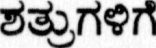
ಶತ್ರುಗಳಿಗೆ
